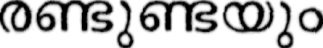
രണ്ടുണ്ടയും
